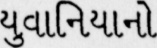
યુવાનિયાનો
